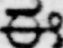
ಈ
